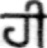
ਹੀ
